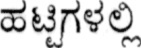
ಹಟ್ಟಿಗಳಲ್ಲಿ
